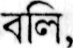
বলি,
